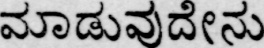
ಮಾಡುವುದೇನು
